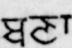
ਬਣਾ
